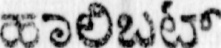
ಹಾಲಿಬಟ್
